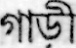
গাড়ী
